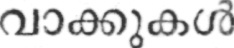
വാക്കുകള്‍
